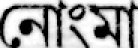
নোংমা
